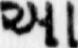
આ
